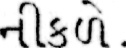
નીકળે.
